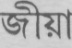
জীয়া
